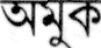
অমুক
